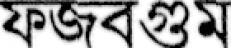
ফজবগুম
